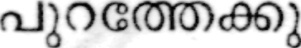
പുറത്തേക്കു
